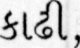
કાઢી,
